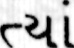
ત્યાં
